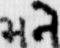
મને
